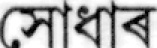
সোধাৰ
